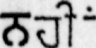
ਨਹੀਂ
